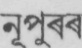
নূপুৰৰ
